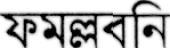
ফমল্লবনি
